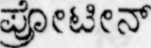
ಪ್ರೋಟೀನ್
